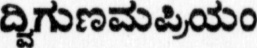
ದ್ವಿಗುಣಮಪ್ರಿಯ೦
